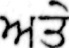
ਅਤੇ
